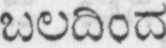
ಬಲದಿಂದ
